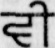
ਵੀ
